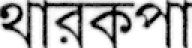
থারকপা
